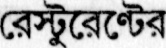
রেস্টুরেণ্টের
